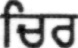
ਚਿਰ
